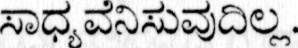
ಸಾಧ್ಯವೆನಿಸುವುದಿಲ್ಲ.
